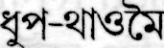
ধুপ-থাওমৈ
